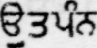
ਉਤਪੰਨ
